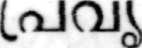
പ്രവൃ
